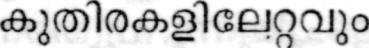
കുതിരകളിലേറ്റവും
